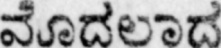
ಮೊದಲಾದ
